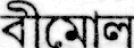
বীমোল
